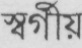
স্বৰ্গীয়
